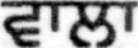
ਵਾਲਾ
